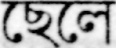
ছেলে
